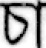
চা
